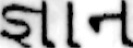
જ્ઞાન
